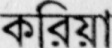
করিয়া
